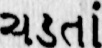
ચડતાં
